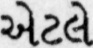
એટલે
